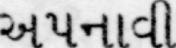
અપનાવી
